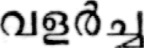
വളര്‍ച്ച
